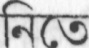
নিতে
